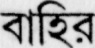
বাহির
